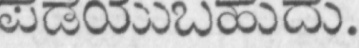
ಪಡೆಯುಬಹುದು.
